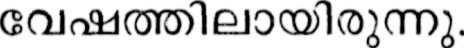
വേഷത്തിലായിരുന്നു.
